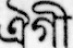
ঐগী
